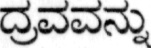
ದ್ರವವನ್ನು
